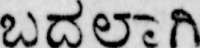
ಬದಲಾಗಿ
